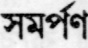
সমর্পণ
